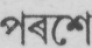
পৰশে
